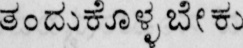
ತಂದುಕೊಳ್ಳಬೇಕು
